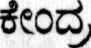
ಕೇಂದ್ರ
